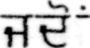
ਜਦੋਂ
